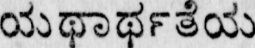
ಯಥಾರ್ಥತೆಯ
